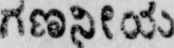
ಗಣನೀಯ
